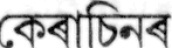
কেৰাচিনৰ
